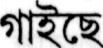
গাইছে
